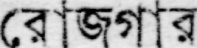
রোজগার
